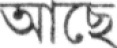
আছে
